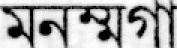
মনম্মগা
